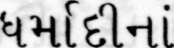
ધર્માદીનાં
